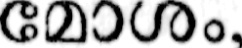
മോശം,
